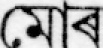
মোৰ
